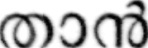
താന്‍
